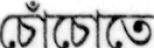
চোঁচোতে
